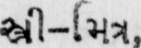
સ્ત્રી-મિત્ર,
